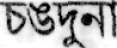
চঙদুনা
